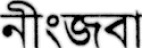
নীংজবা
